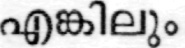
എങ്കിലും
